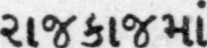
રાજકાજમાં
